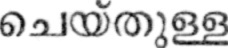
ചെയ്തുള്ള
